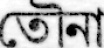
তৌনা
